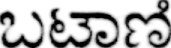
ಬಟಾಣಿ
